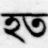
হত
